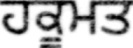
ਹਕੂਮਤ
